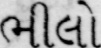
ભીલો
